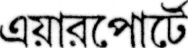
এয়ারপোর্টে
